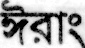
ঈরাং
